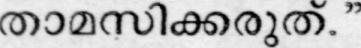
താമസിക്കരുത്.”
